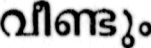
വീണ്ടും
